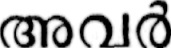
അവര്‍
